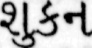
શુકન
